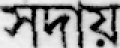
সদায়
